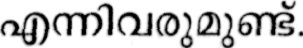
എന്നിവരുമുണ്ട്.
